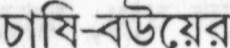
চাষি-বউয়ের
